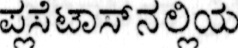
ಪ್ಲಸೆಟಾಸ್ನಲ್ಲಿಯ
